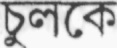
চুলকে
